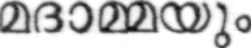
മദാമ്മയും
